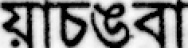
য়াচঙবা
